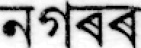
নগৰৰ
